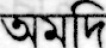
অমদি
